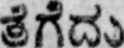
ತೆಗೆದು
